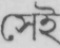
সেই
